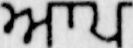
ਆਪ
